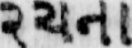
રચના
